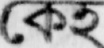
কেহ
